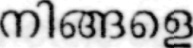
നിങ്ങളെ
